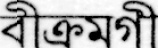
বীক্রমগী
